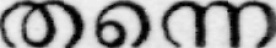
തന്നെ
